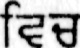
ਵਿਚ
